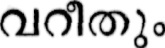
വറീതും
